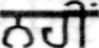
ਨਹੀਂ
